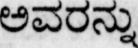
ಅವರನ್ನು
